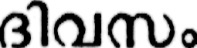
ദിവസം
